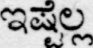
ಇಷ್ಟೆಲ್ಲ
